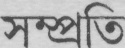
সম্প্ৰতি
